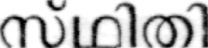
സ്ഥിതി
